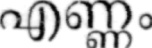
എണ്ണം
